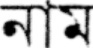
নাম
